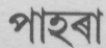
পাহৰা
